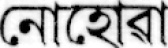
নোহোৱা
